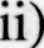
ii)
